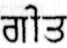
ਗੀਤ
